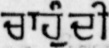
ਚਾਹੁੰਦੀ
